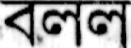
বলল
